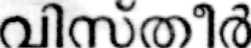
വിസ്തീര്‍
